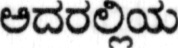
ಅದರಲ್ಲಿಯ
